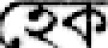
হেক
